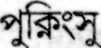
পুক্নিংসু
